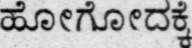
ಹೋಗೋದಕ್ಕೆ
